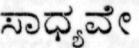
ಸಾಧ್ಯವೇ
